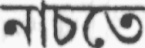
নাচতে
